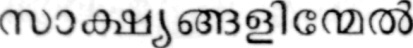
സാക്ഷ്യങ്ങളിന്മേല്‍
